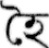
হৈ
